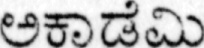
ಅಕಾಡೆಮಿ
